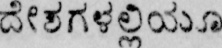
ದೇಶಗಳಲ್ಲಿಯೂ
